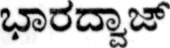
ಭಾರದ್ವಾಜ್
